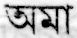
অমা
